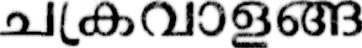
ചക്രവാളങ്ങ
